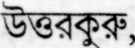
উত্তরকুরু,
